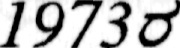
1973ರ
